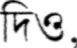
দিও,
